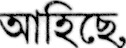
আহিছে,
